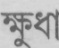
ক্ষুধা
